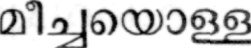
മീച്ചയൊള്ള
